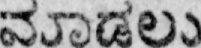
ಮಾಡಲು
